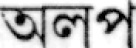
অলপ
